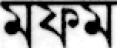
মফম
